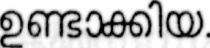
ഉണ്ടാക്കിയ.
